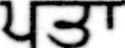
ਪਤਾ
